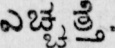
ಎಚ್ಚತ್ತೆ.
